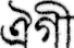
ঐগী
